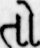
તો
